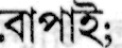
বোপাই;
